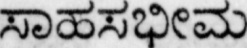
ಸಾಹಸಭೀಮ
